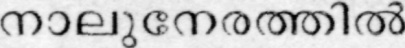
നാലുനേരത്തില്‍
